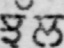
ਝੱਲ
